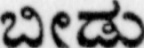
ಬೀಡು
